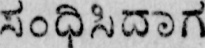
ಸಂಧಿಸಿದಾಗ
